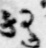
કરું
